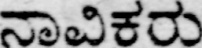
ನಾವಿಕರು
